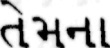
તેમના
